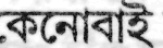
কেনোবাই
